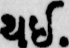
થઈ.
